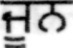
ਜੂਨ
